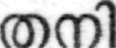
തനി
